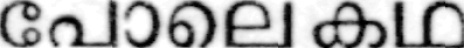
പോലെകഥ
